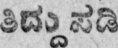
ತಿದ್ದುಪಡಿ
